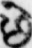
છે
